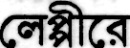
লেপ্পীরে
